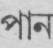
পান
